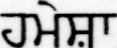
ਹਮੇਸ਼ਾ
